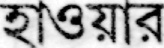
হাওয়ার
